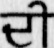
ਦੀ
